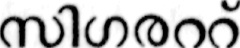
സിഗരററ്
